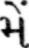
મેં
